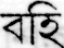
বহি
